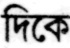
দিকে
